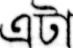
এটা
